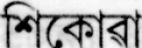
শিকোৱা
